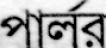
পার্লর
